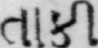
તાકી
